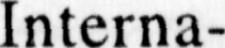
Interna-
